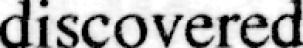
discovered
